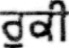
ਰੁਕੀ
